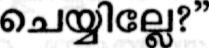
ചെയ്യില്ലേ?”
